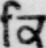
ਕਿ
